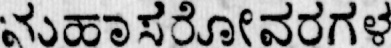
ಮಹಾಸರೋವರಗಳ
